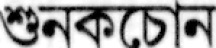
শুনকচোন
